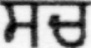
ਸਚ
